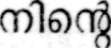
നിന്റെ
